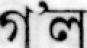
গ'ল
